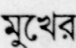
মুখের
